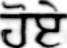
ਹੋਏ
